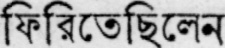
ফিরিতেছিলেন
